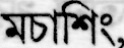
মচাশিং,
